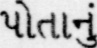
પોતાનું
